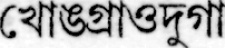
খোঙগ্রাওদুগা
